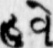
હવે
